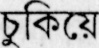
চুকিয়ে
